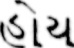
હોય
